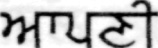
ਆਪਣੀ
